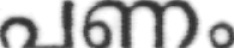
പണം
